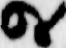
જ
